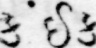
કંઈક
